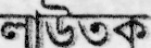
লাউতক
